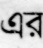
এর
